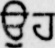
ਉਹ
